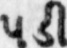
પડી
